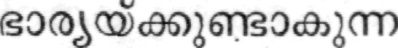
ഭാര്യയ്ക്കുണ്ടാകുന്ന
